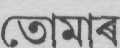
তোমাৰ
